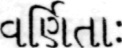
વર્ણિતાઃ
